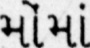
મોમાં
